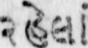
રહેલાં
